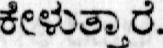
ಕೇಳುತ್ತಾರೆ.
